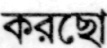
করছো
